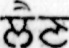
ਲੈਣ
